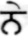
ਨੇ
